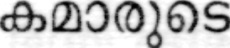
കമാരുടെ
